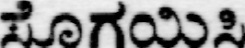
ಸೊಗಯಿಸಿ
